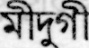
মীদুগী
